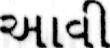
આવી
